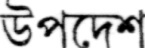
উপদেশ
